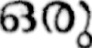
ഒരു
